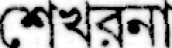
শেখরনা
